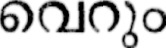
വെറും
